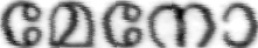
മേനോ
